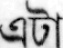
এটা
